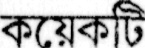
কয়েকটি
